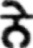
ਨੇ
